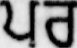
ਪਰ
